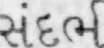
સંદર્ભ
